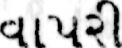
વાપરી
